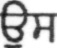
ਉਸ
